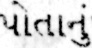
પોતાનું
